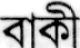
বাকী
